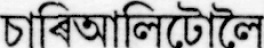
চাৰিআলিটোলৈ
